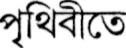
পৃথিবীতে
